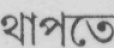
থাপতে
